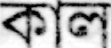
কাল
